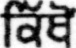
ਕਿੱਥੋਂ
